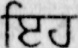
ਇਹ
